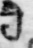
ਹੈ,
